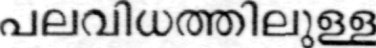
പലവിധത്തിലുള്ള
